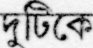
দুটিকে
